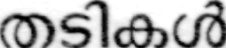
തടികള്‍
